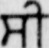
ਸੀ
